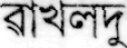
ৱাখলদু
